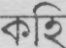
কহি
